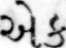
એક
